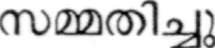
സമ്മതിച്ചു
